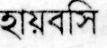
হায়বসি
